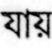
যায়
